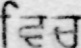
ਵਿਚ
